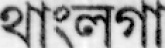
থাংলগা
